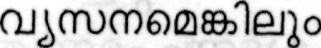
വ്യസനമെങ്കിലും
